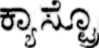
ಕ್ಯಾಸ್ಟ್ರೊ
